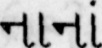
નાનાં
